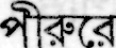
পীরুরে
